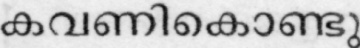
കവണികൊണ്ടു
